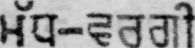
ਮੱਧ-ਵਰਗੀ
